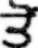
ਤੋਂ
